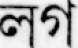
লগ
